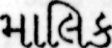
માલિક
